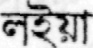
লইয়া
